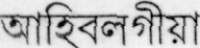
আহিবলগীয়া
